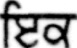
ਇਕ
